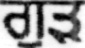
ਗੁੜ
